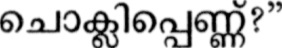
ചൊക്ലിപ്പെണ്ണ്?”
